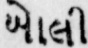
બોલી
